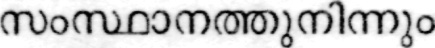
സംസ്ഥാനത്തുനിന്നും
